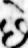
છે
